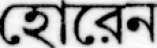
হোরেন
